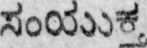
ಸಂಯುಕ್ತ
